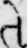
તે
